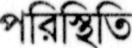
পরিস্থিতি
